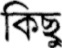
কিছু
